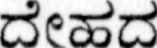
ದೇಹದ
